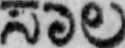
ಸಾಲ
